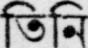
তিনি
